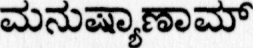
ಮನುಷ್ಯಾಣಾಮ್
